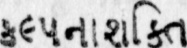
કલ્પનાશક્તિ
